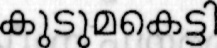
കുടുമകെട്ടി
